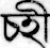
চহী
